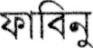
ফাবিনু
